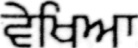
ਵੇਖਿਆ
